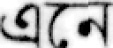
এনে
